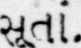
સૂતાં.
